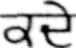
ਕਦੇ
